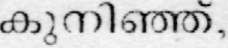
കുനിഞ്ഞ്,
